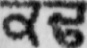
ਕਢ
